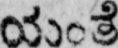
ಯಂತೆ
